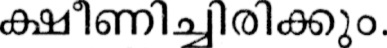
ക്ഷീണിച്ചിരിക്കും.
